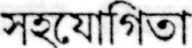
সহযোগিতা
